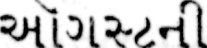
ઑગસ્ટની
